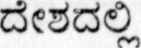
ದೇಶದಲ್ಲಿ
